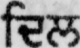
ਦਿਲ
